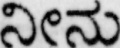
ನೀನು
